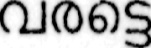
വരട്ടെ
